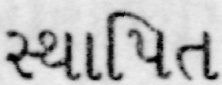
સ્થાપિત
